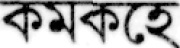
কমকহে
